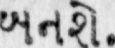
બનશે.
